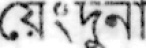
য়েংদুনা
